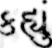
કહ્યું
